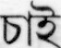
চাই
